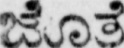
ಜೊತೆ
